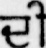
ਦੀ
